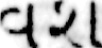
વશ
